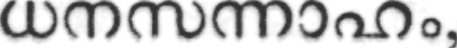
ധനസന്നാഹം,
